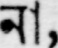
না,
